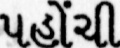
પહોંચી
